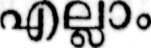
എല്ലാം
